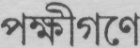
পক্ষীগণে
